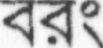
বরং
